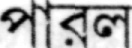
পারল
